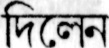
দিলেন
